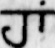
ਹਾਂ
